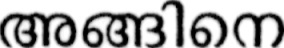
അങ്ങിനെ
